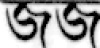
জজ
